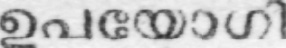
ഉപയോഗി
